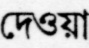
দেওয়া
